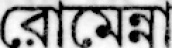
রোমেন্না
